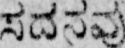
ಸದನವು
